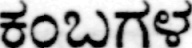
ಕಂಬಗಳ
